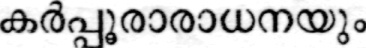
കര്‍പ്പൂരാരാധനയും
